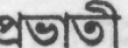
প্রভাতী
